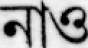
নাও
